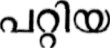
പറ്റിയ
